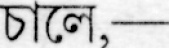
চালে,-
